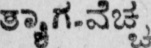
ತ್ಯಾಗ-ವೆಚ್ಚ
